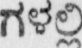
ಗಳಲ್ಲಿ
